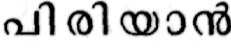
പിരിയാന്‍
